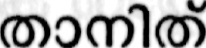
താനിത്
